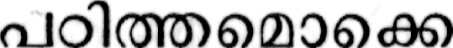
പഠിത്തമൊക്കെ
